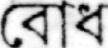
বোধ
